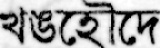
খঙহৌদে
